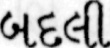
બદલી
